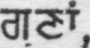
ਗਣਾਂ,
